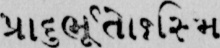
પ્રાદુર્ભૂતોઽસ્મિ
